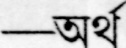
–অর্থ
